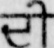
ਦੀ
